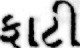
ફાટી
